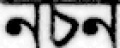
নচন
